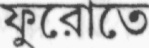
ফুরোতে
